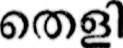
തെളി
